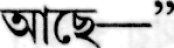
আছে-"
